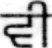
ਵੀ
